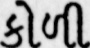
કોળી
